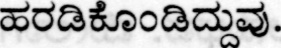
ಹರಡಿಕೊಂಡಿದ್ದುವು.
